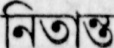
নিতান্ত
